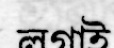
লগাই
